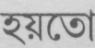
হয়তো
